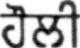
ਹੌਲੀ
